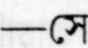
–সে
